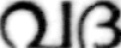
വദ
